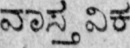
ವಾಸ್ತವಿಕ
